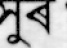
সুৰ
